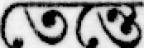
তেন্তে
